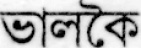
ভালকৈ
